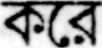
করে
